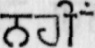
ਨਹੀਂ
